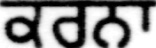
ਕਰਨਾ
